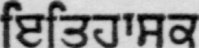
ਇਤਿਹਾਸਕ
